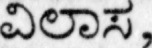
ವಿಲಾಸ,
